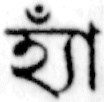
হ্যাঁ
